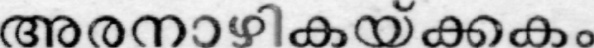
അരനാഴികയ്ക്കകം.
